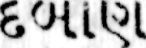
દબાણ
